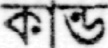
কান্ড
